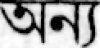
অন্য
